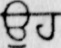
ਉਹ
